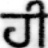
ਹੀ
